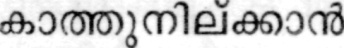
കാത്തുനില്ക്കാന്‍
